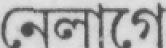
নেলাগে
